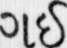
ગઈ
